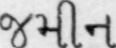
જમીન
